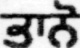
ਭਾਨੋ
